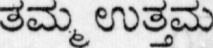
ತಮ್ಮಉತ್ತಮ
